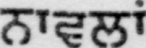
ਨਾਵਲਾਂ
